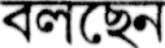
বলছেন
